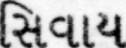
સિવાય
